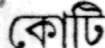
কোটি
